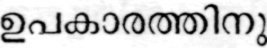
ഉപകാരത്തിനു
